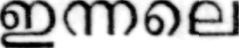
ഇന്നലെ
